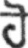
ਹੋ
